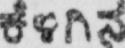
ಕೆಳಗಿನ
